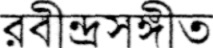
রবীন্দ্রসঙ্গীত
